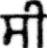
ਸੀ
